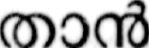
താന്‍
